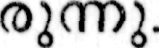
രുന്നു.
